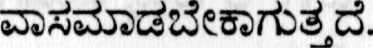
ವಾಸಮಾಡಬೇಕಾಗುತ್ತದೆ.
